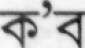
ক'ব
